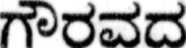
ಗೌರವದ
